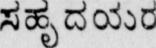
ಸಹೃದಯರ
